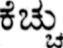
ಕೆಚ್ಚು
